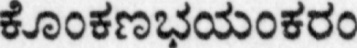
ಕೊಂಕಣಭಯಂಕರಂ
